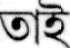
তাই
